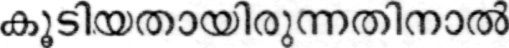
കൂടിയതായിരുന്നതിനാല്‍
